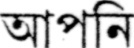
আপনি
